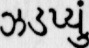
ઝડપ્યું
